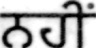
ਨਹੀਂ
